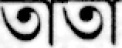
তাতা
